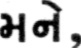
મને,
